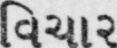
વિચાર
